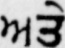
ਅਤੇ
